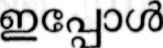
ഇപ്പോള്‍
